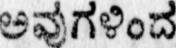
ಅವುಗಳಿಂದ
